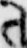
તે
